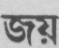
জয়
